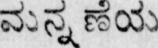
ಮನ್ನಣೆಯ
